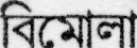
বিমোলা
